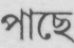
পাছে
